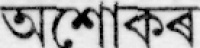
অশোকৰ
